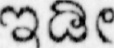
ಇಡೀ
